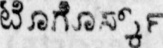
ಟೊಗೊರ್ಸ್ಕ್
